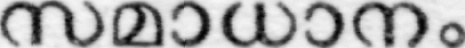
സമാധാനം
